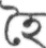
হৈ
